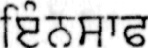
ਇੰਨਸਾਫ
